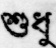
শুধু
